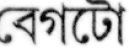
বেগটো
